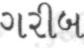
ગરીબ
